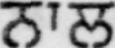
ਨਾਲ
